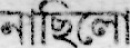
নাছিলো
